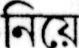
নিয়ে
